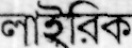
লাইরিক
